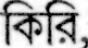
কিরি,
